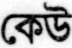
কেউ
